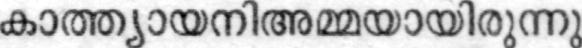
കാത്ത്യായനിഅമ്മയായിരുന്നു
